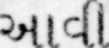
આવી
